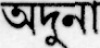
অদুনা
